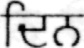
ਦਿਨ
